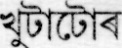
খুটাটোৰ
